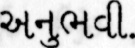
અનુભવી.
